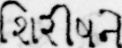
શિરીષને
